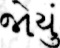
જોયું
